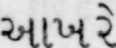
આખરે
